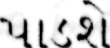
પાડશે
